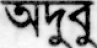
অদুবু
